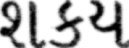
શક્ય
